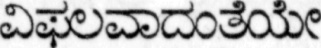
ವಿಫಲವಾದಂತೆಯೇ
